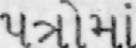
પત્રોમાં
